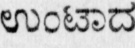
ಉಂಟಾದ
